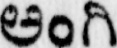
ಅಂಗಿ
